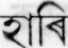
হাৰি
